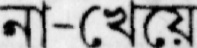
না-খেয়ে
